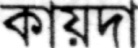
কায়দা
